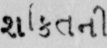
શક્તિની
